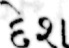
દેશ
